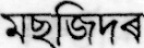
মছজিদৰ
